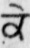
ਕੇ
